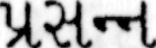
પ્રસન્ન
